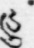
હું
